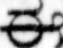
ಈ
